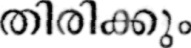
തിരിക്കും
